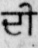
ਦੀ
